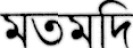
মতমদি
